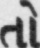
તો
